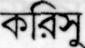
করিসু
